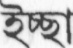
ইচ্ছা
